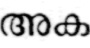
അക
